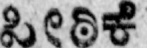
ಪೀಠಿಕೆ
